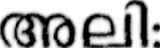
അലി:
